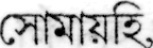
সোমায়হি,
